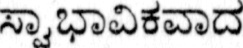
ಸ್ವಾಭಾವಿಕವಾದ
